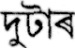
দুটাৰ
